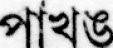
পাখঙ
